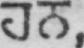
ਹਨ,
